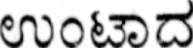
ಉಂಟಾದ
